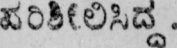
ಪರಿಶೀಲಿಸಿದ್ದ.
